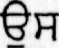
ਉਸ
